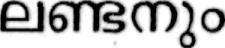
ലണ്ടനും
